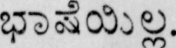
ಭಾಷೆಯಿಲ್ಲ.
